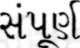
સંપૂર્ણ
